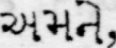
અમને,
